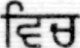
ਵਿਚ
